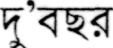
দু’বছর
